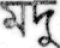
মদু
